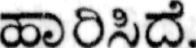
ಹಾರಿಸಿದೆ.
